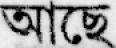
আছে
